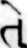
તે
